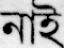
নাই
